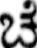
ಚೆ
